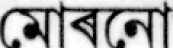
মোৰনো
